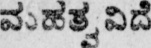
ಮಹತ್ವವಿದೆ
